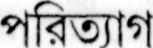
পরিত্যাগ
